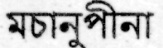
মচানুপীনা
